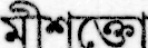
মীশক্তো
